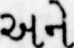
અને
